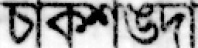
চাকশঙদা
